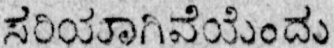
ಸರಿಯಾಗಿವೆಯೆಂದು
